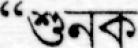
"শুনক
